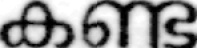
കണ്ട
